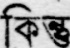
কিন্তু
